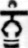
ਨੂੰ
